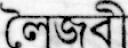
লৈজবী
